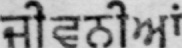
ਜੀਵਨੀਆਂ
